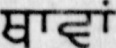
ਥਾਵਾਂ
